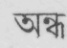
অন্ধ
